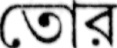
তোর
